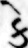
કે
